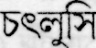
চৎলুসি
